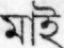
মাই
